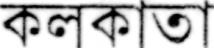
কলকাতা
